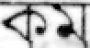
কম
